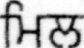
ਮਿਲ
